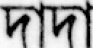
দাদা
